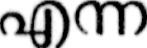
എന്ന
